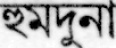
হুমদুনা
